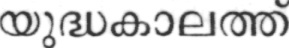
യുദ്ധകാലത്ത്
